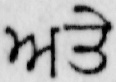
ਅਤੇ
